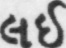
લઈ
